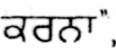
ਕਰਨਾ'',
